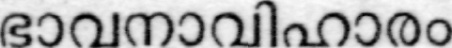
ഭാവനാവിഹാരം
